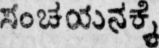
ಸಂಚಯನಕ್ಕೆ
